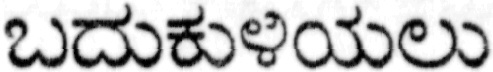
ಬದುಕುಳಿಯಲು
